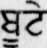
ਬੂਟੇ
